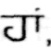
ਹਾਂ,
